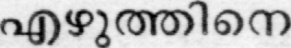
എഴുത്തിനെ
